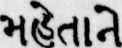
મહેતાને
